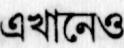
এখানেও
